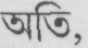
অতি,
